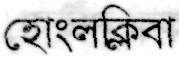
হোংলক্লিবা
